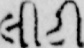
લીટી
